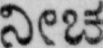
ನೀಚ
